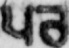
ਪਰ
